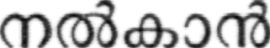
നല്‍കാന്‍
